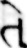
તે
